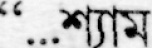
"...শ্যাম
